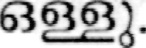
ഒള്ളു.
